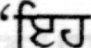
'ਇਹ
